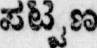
ಪಟ್ಟಣ
